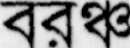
বরঞ্চ
